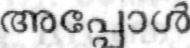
അപ്പോള്‍
